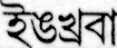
ইঙখ্রবা
